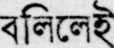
বলিলেই
